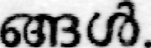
ങ്ങള്‍.
